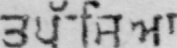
ਤਪੱਸਿਆ
